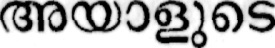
അയാളുടെ
